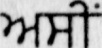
ਅਸੀਂ
